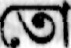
তো
